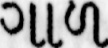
ગાળ
